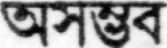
অসম্ভব
